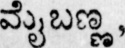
ಮೈಬಣ್ಣ,
